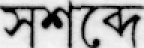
সশব্দে
